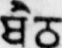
ਬੈਠ
